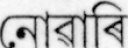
নোৱাৰি
